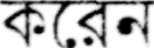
করেন
